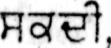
ਸਕਦੀ,
